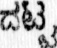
ದಟ್ಟ
